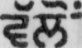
ਵੱਲੋਂ
